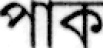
পাক
